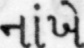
નાંખે
